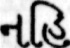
નહિ
